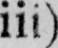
iii)
